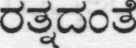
ರತ್ನದಂತೆ
